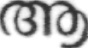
ആ
